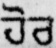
ਹੋਰ
